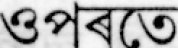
ওপৰতে
